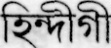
হিন্দীগী
